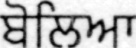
ਬੋਲਿਆ
